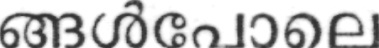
ങ്ങള്‍പോലെ
